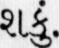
શકું.
